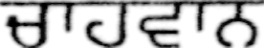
ਚਾਹਵਾਨ
